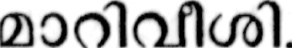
മാറിവീശി.
